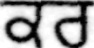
ਕਰ
